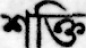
শক্তি
